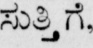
ಸುತ್ತಿಗೆ,
